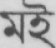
মই
